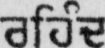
ਰਹਿੰਦ
